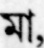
মা,
